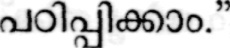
പഠിപ്പിക്കാം.”
